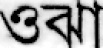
ওঝা
